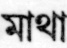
মাথা
